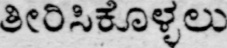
ತೀರಿಸಿಕೊಳ್ಳಲು
